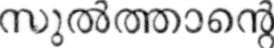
സുല്‍ത്താന്റെ
